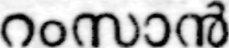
റംസാന്‍
